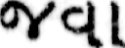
જવા
